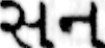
સન
